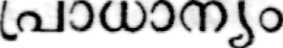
പ്രാധാന്യം
